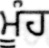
ਮੂੰਹ
